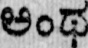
ಅಂಥ
